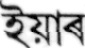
ইয়াৰ
